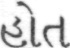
હોત
